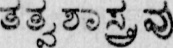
ತತ್ವಶಾಸ್ತ್ರವು
